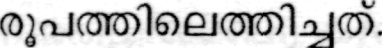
രൂപത്തിലെത്തിച്ചത്.
